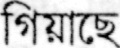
গিয়াছে
